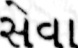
સેવા
